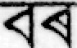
বৰ
